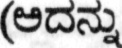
(ಅದನ್ನು
